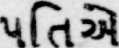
પતિએ
